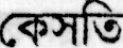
কেসতি
